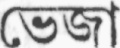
ভেজা
